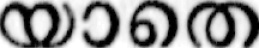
യാതെ
